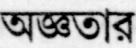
অজ্ঞতার
